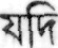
যদি
